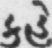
કહે
